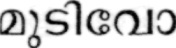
മുടിവോ
